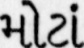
મોટાં
